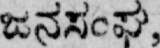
ಜನಸಂಘ,
